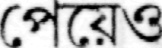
পেয়েও
